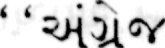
"અંગ્રેજ
